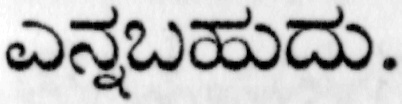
ಎನ್ನಬಹುದು.
